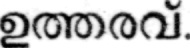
ഉത്തരവ്.
